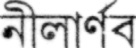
নীলার্ণব
